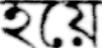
হয়ে
